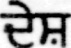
ਦੇਸ਼
